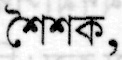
শৈশক,
